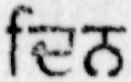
ਦਿਨ
